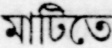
মাটিতে
